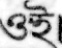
ওই।
